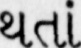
થતાં
